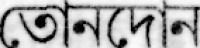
তোনদোন
